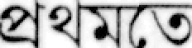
প্রথমতে
